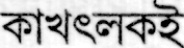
কাখৎলকই
